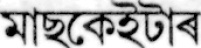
মাছকেইটাৰ
